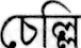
চেল্লি
